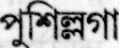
পুশিল্লগা
